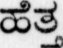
ಹೆತ್ತ
